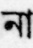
না
